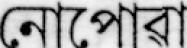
নোপোৱা
